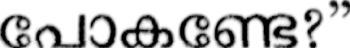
പോകണ്ടേ?”
